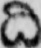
ದಿ
